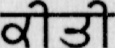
ਕੀਤੀ
